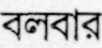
বলবার
